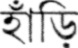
হাঁড়ি
